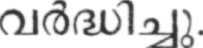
വര്‍ദ്ധിച്ചു.
